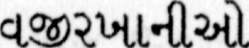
વજીરખાનીઓ
